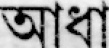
আধা
